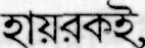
হাযরকই,
